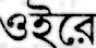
ওইরে
